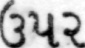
ઉપર
